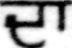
ਦਾ
